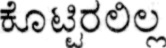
ಕೊಟ್ಟಿರಲಿಲ್ಲ
